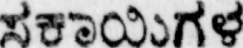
ಸಕಾಯಿಗಳ
